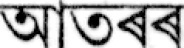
আতৰৰ
